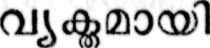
വ്യക്തമായി
